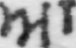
ਆ
